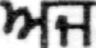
ਅਜ
